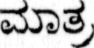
ಮಾತ್ರ
